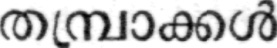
തമ്പ്രാക്കള്‍
